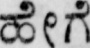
ಹೇಗೆ
